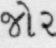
જોર
